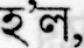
হ'ল,
